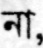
না,
